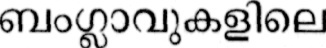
ബംഗ്ലാവുകളിലെ
